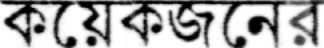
কয়েকজনের
